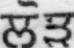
ਲੋੜ
